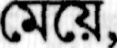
মেয়ে,
